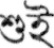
শুই
